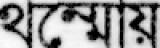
থম্মোয়
